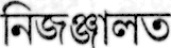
নিজঞ্জালত
